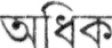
অধিক
